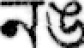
নঙ
